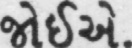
જોઈએ.
